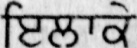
ਇਲਾਕੇ
